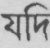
যদি
